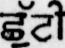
ਛੁੱਟੀ
